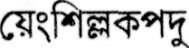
য়েংশিল্লকপদু
